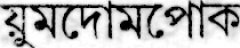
য়ুমদোমপোক
